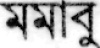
মমাবু
